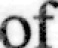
of
